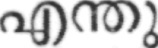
എന്തു
